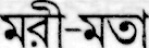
মরী-মতা
